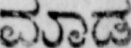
ಮಾಡ
